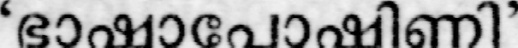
‘ഭാഷാപോഷിണി’
